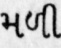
મળી
